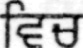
ਵਿਚ
